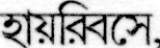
হায়রিবসে,
